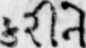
કરીને
